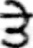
ਤੇ
